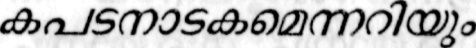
കപടനാടകമെന്നറിയും
